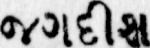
જગદીશ
